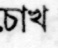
চোখ
